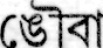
ঙৌবা
